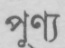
পুণ্য
